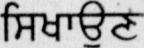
ਸਿਖਾਉਣ
